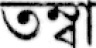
তম্বা
